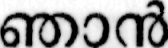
ഞാന്‍
